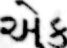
એક
